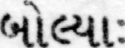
બોલ્યા:
